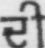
ਦੀ
